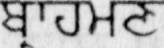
ਬ੍ਰਾਹਮਣ
